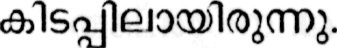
കിടപ്പിലായിരുന്നു.
